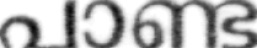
പാണ്ട
